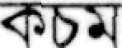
কচম
